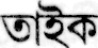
তাইক
